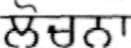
ਲੋਚਨਾ
